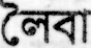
লৈবা
